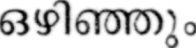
ഒഴിഞ്ഞും
